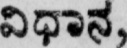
ವಿಧಾನ,
